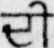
ਦੀ
